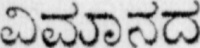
ವಿಮಾನದ
